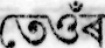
তেওঁৰ
